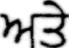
ਅਤੇ
